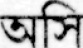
অসি
